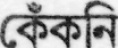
কেঁকনি
